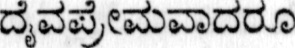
ದೈವಪ್ರೇಮವಾದರೂ
